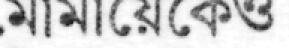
মোমায়েকেও
